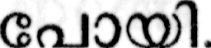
പോയി.
